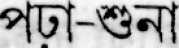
পঢ়া-শুনা
